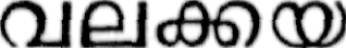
വലക്കയ
